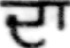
ਦਾ
